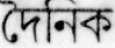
দৈনিক
